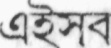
এইসব
